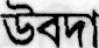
উবদা
